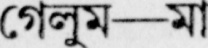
গেলুম-মা
